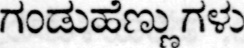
ಗಂಡುಹೆಣ್ಣುಗಳು
